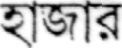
হাজার
